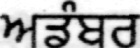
ਅਡੰਬਰ
